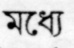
মধ্যে
